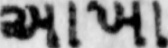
આખા
